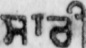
ਸਾਰੀ
